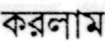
করলাম
